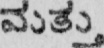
ಮತ್ತು
